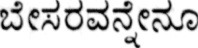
ಬೇಸರವನ್ನೇನೂ
